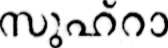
സുഹ്റാ
